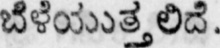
ಬೆಳೆಯುತ್ತಲಿದೆ.
